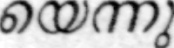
യെന്നു
